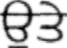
ਉਤੇ
